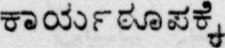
ಕಾರ್ಯರೂಪಕ್ಕೆ
